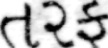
તરફ
